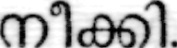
നീക്കി.
